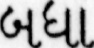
બધા
